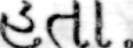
હતા.
